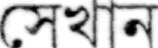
সেখান
